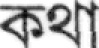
কথা
